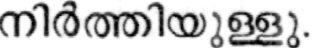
നിര്‍ത്തിയുള്ളു.
